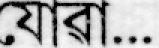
যোৱা...
